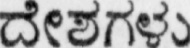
ದೇಶಗಳು
